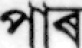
পাৰ
